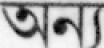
অন্য
